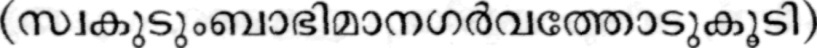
(സ്വകുടുംബാഭിമാനഗര്‍വത്തോടുകൂടി)
